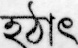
হঠাৎ
